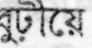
বুঢ়ীয়ে
